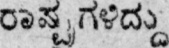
ರಾಷ್ಟ್ರಗಳಿದ್ದು
